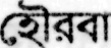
হৌরবা
